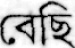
বেছি
